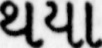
થયા
